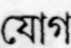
যোগ
